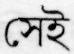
সেই
